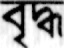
বৃদ্ধ
